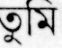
তুমি
